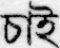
চাই
